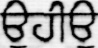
ਉਹੀਉ
